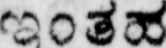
ಇಂತಹ
